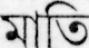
মাতি
